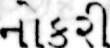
નોકરી
